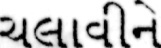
ચલાવીને
